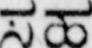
ಸಹ
